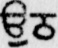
ਉਠ
